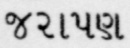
જરાપણ
